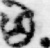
છે.
